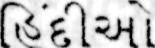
હિંદીઓ
